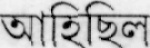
আহিছিল
